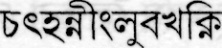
চৎহন্নীংলুবখক্নি
